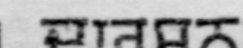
ਦਾਰਸਨ
